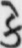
કે
